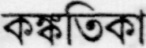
কঙ্কতিকা
